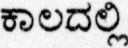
ಕಾಲದಲ್ಲಿ
